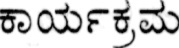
ಕಾರ್ಯಕ್ರಮ
